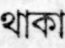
থাকা
